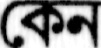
কেন
